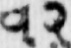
વર
